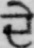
ਦੇ
